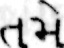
તમે
